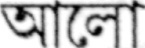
আলো
